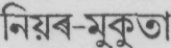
নিয়ৰ-মুকুতা
